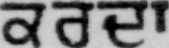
ਕਰਦਾ
